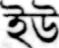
ইউ
